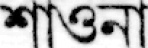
শাওনা
